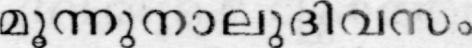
മൂന്നുനാലുദിവസം
